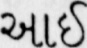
આઈ
